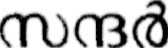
സന്ദര്‍
